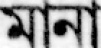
মানা
